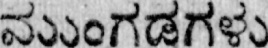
ಮುಂಗಡಗಳು
